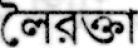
লৈরক্তা
